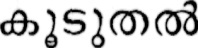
കൂടുതല്‍
